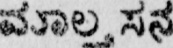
ಮಾಲ್ತಸನ
